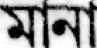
মানা
